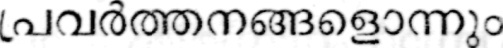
പ്രവര്‍ത്തനങ്ങളൊന്നും
